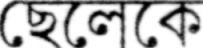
ছেলেকে
